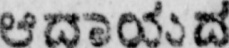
ಆದಾಯದ
